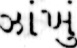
ઝાંખુ
